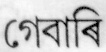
গেবাৰি
